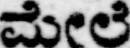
ಮೇಲೆ
